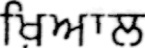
ਖ਼ਿਆਲ
